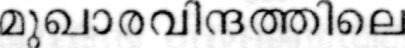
മുഖാരവിന്ദത്തിലെ
